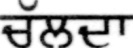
ਚੱਲਦਾ
